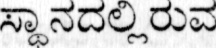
ಸ್ಥಾನದಲ್ಲಿರುವ
